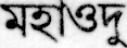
মহাওদু
